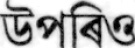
উপৰিও
